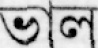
ভাল
